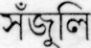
সঁজুলি
